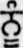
ਨੂੰ
